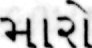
મારો
